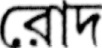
রোদ
